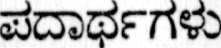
ಪದಾರ್ಥಗಳು
